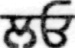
ਲਓ
